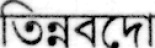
তিন্নবদো
